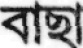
বাছা
